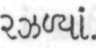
રઝળ્યાં.
